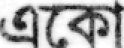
একো
